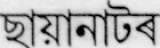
ছায়ানাটৰ
